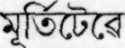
মূর্তিটেৱে
